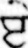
ਏ
